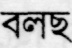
বলছ
